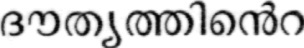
ദൌത്യത്തിന്റെ
